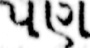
પણ
